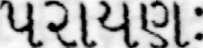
પરાયણઃ
